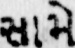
સામે
